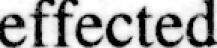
effected
